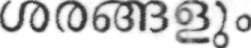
ശരങ്ങളും
